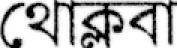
থোক্লবা
